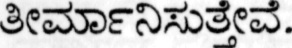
ತೀರ್ಮಾನಿಸುತ್ತೇವೆ.
